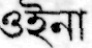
ওইনা
